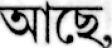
আছে,
